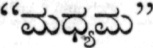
“ಮಧ್ಯಮ’’
